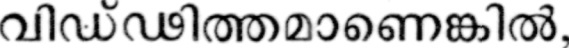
വിഡ്ഢിത്തമാണെങ്കില്‍,
